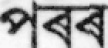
পৰৰ
